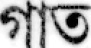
গাত
